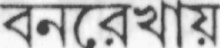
বনরেখায়
